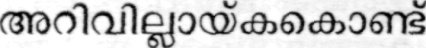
അറിവില്ലായ്കകൊണ്ട്
